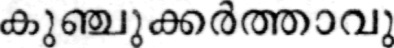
കുഞ്ചുക്കര്‍ത്താവു
